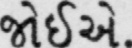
જોઈએ.
